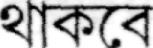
থাকবে
